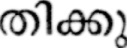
തിക്കു
